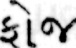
ફોજ
